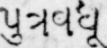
પુત્રવધૂ
